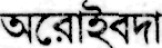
অরোইবদা
